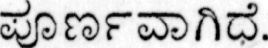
ಪೂರ್ಣವಾಗಿದೆ.
